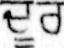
ਦੂਰ
